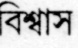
বিশ্বাস
